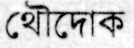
থৌদোক
